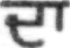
ਦਾ
